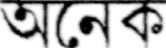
অনেক
